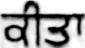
ਕੀਤਾ
